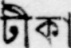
টীকা
